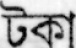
টকা
